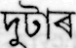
দুটাৰ
